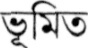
ভূমিত
